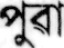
পুৱা
